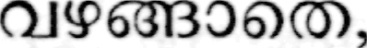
വഴങ്ങാതെ,
